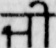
ਜੀ
